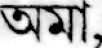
অমা,
